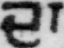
ਦਾ
